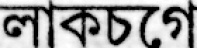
লাকচগে
